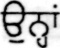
ਉਨ੍ਹਾਂ
